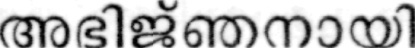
അഭിജ്ഞനായി
